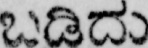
ಬಡಿದು
